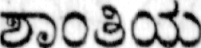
ಶಾಂತಿಯ
